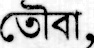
তৌবা,
